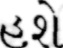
હશે
